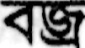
বজ্র
